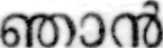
ഞാന്‍
